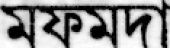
মফমদা
